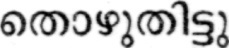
തൊഴുതിട്ടു
